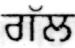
ਗੱਲ
